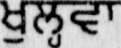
ਖੁਲ੍ਹਵਾ
